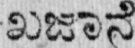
ಖಜಾನೆ
